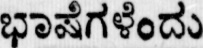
ಭಾಷೆಗಳೆಂದು
